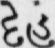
દેહ
